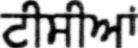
ਟੀਸੀਆਂ
